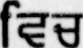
ਵਿਚ
